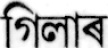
গিলাৰ
